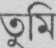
তুমি
